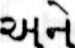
અને
